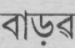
বাড়ৱ
